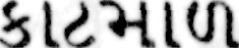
કાટમાળ
